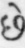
છે
